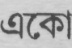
একো
